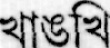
খাঙখি
